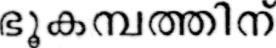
ഭൂകമ്പത്തിന്
